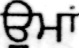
ਉਮਾਂ
